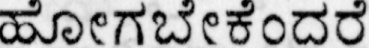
ಹೋಗಬೇಕೆಂದರೆ
